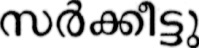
സര്‍ക്കീട്ടു
